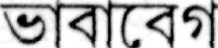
ভাবাবেগ
